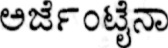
ಅರ್ಜೆಂಟೈನಾ
